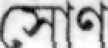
সোণ
